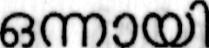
ഒന്നായി
